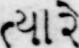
ત્યારે
